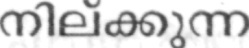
നില്ക്കുന്ന
